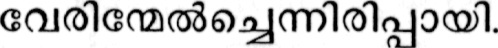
വേരിന്മേല്‍ച്ചെന്നിരിപ്പായി.
